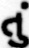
તું
